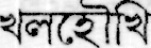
খলহৌখি
